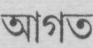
আগত
